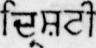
ਦ੍ਰਿਸ਼ਟੀ
